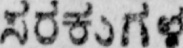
ಸರಕುಗಳ
